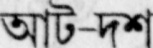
আট-দশ
